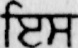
ਇਸ
